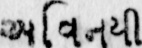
અવિનયી
